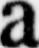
a
